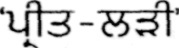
'ਪ੍ਰੀਤ-ਲੜੀ'
